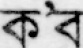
ক'ব
